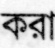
করা
